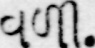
વળી.
